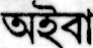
অইবা
